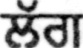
ਲੱਗ
